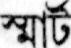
স্মার্ট
